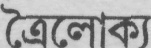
ত্ৰৈলোক্য
